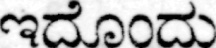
ಇದೊಂದು
